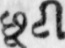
છૂટી
